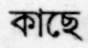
কাছে
